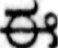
ಈ
